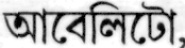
আবেলিটো,
